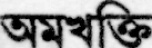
অমখক্তি
